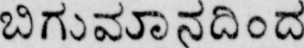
ಬಿಗುಮಾನದಿಂದ
